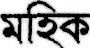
মহিক
